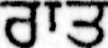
ਰਾਤ
